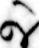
જે
